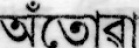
অঁতোৱা
